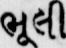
ભૂલી
